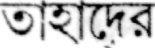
তাহাদের
